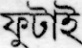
ফুটাই
